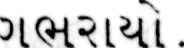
ગભરાયો.
